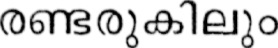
രണ്ടരുകിലും
